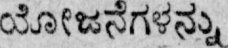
ಯೋಜನೆಗಳನ್ನು
